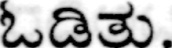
ಓಡಿತು.
